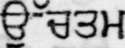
ਉੱਚਤਮ
